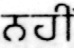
ਨਹੀਂ
